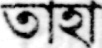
তাহা
